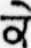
ਕੇ
